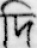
দি
